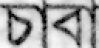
চাবা
